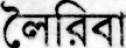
লৈরিবা
